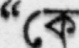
‘‘কে
